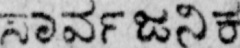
ಸಾರ್ವಜನಿಕ
